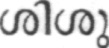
ശിശു
